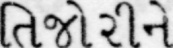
તિજોરીને
